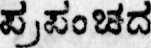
ಪ್ರಪಂಚದ
